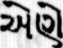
એણે
